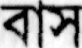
বাস
